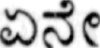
ಏನೇ
